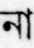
না
